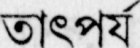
তাৎপর্য
